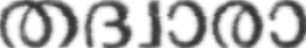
തദ്വാരാ
